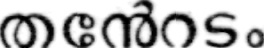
തന്റേടം
